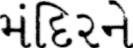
મંદિરને
